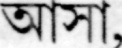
আসা,
